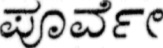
ಪೂರ್ವೇ
